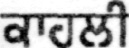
ਕਾਹਲੀ
